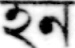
হন
